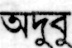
অদুবু
